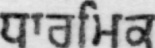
ਧਾਰਮਿਕ
